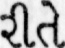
રીતે
